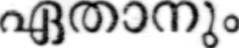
ഏതാനും
